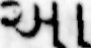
આ
